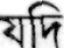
যদি
